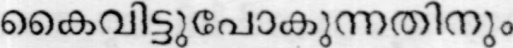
കൈവിട്ടുപോകുന്നതിനും
